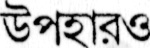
উপহারও
